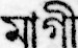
মাগী
